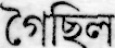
গৈছিল
